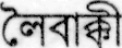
লৈবাক্কী
